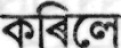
কৰিলে
